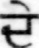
ਦੇ
